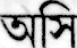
অসি
